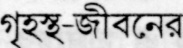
গৃহস্থ-জীবনের
